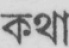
কথা
